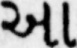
આ
